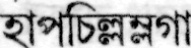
হাপচিল্লম্লগা
